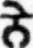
ਨੇ
